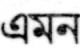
এমন
